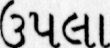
ઉપલા
